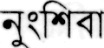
নুংশিবা
